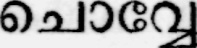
ചൊവ്വേ
